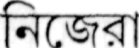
নিজেরা
